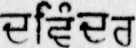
ਦਵਿੰਦਰ
